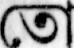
তো
